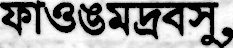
ফাওঙমদ্রবসু,
